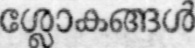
ശ്ലോകങ്ങള്‍
